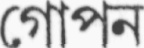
গোপন
